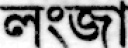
লংজা
